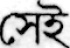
সেই
